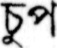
চুপ
